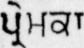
ਪ੍ਰੇਮਕਾ
